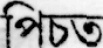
পিচত
